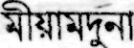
মীয়ামদুনা
